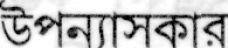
উপন্যাসকার
